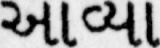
આવ્યા.
